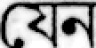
যেন
